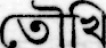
তৌখি
